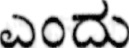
ಎಂದು
